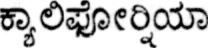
ಕ್ಯಾಲಿಫೋರ್ನಿಯಾ
